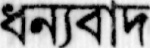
ধন্যবাদ
